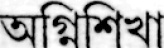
অগ্নিশিখা
